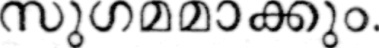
സുഗമമാക്കും.
